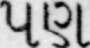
પણ
